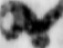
જ
